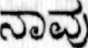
ನಾವು
